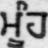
ਮੂੰਹ
